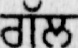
ਗੱਲ
